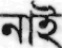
নাই
